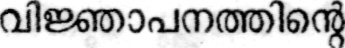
വിജ്ഞാപനത്തിന്റെ
